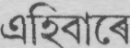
এহিবাৰে
